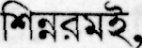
শিন্নরমই,
